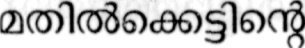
മതില്‍ക്കെട്ടിന്റെ
